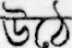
উঠে
